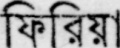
ফিরিয়া
